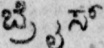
ಬ್ರೈಸ್
